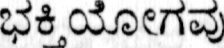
ಭಕ್ತಿಯೋಗವು
